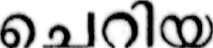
ചെറിയ
